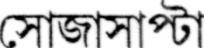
সোজাসাপ্টা
